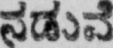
ನಡುವೆ
